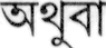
অথুবা
